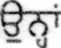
ਉਨ੍ਹਾਂ
